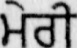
ਮੇਰੀ
